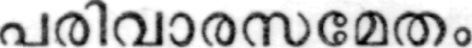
പരിവാരസമേതം
